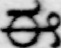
ಈ
